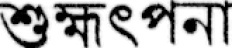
শুহ্মৎপনা
